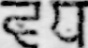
ਵਧ
